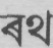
ৰথ
